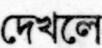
দেখলে
